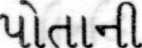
પોતાની
